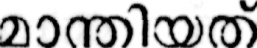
മാന്തിയത്
